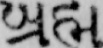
બ્રહ્મ
